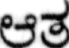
ಆತ
